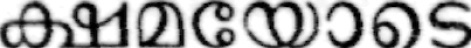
ക്ഷമയോടെ
